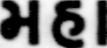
મહા
